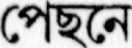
পেছনে
